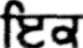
ਇਕ
